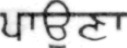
ਪਾਉਣਾ
